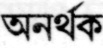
অনর্থক
